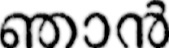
ഞാന്‍
